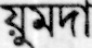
য়ুমদা
